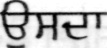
ਉਸਦਾ
